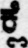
ಕ್ಲೆ
